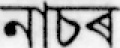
নাচৰ
